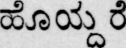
ಹೊಯ್ದರೆ
